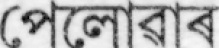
পেলোৱাৰ
